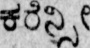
ಕರೆನ್ಸೀ
